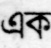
এক
